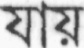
যায়
